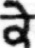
ਕੇ
